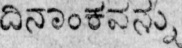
ದಿನಾಂಕವನ್ನು
